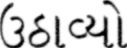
ઉઠાવ્યો
